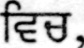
ਵਿਚ,
